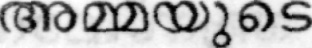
അമ്മയുടെ
